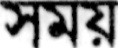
সময়
